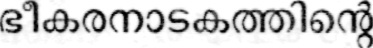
ഭീകരനാടകത്തിന്റെ
